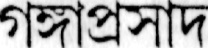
গঙ্গাপ্রসাদ
